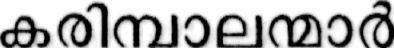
കരിമ്പാലന്മാര്‍
